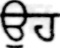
ਉਹ
